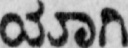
ಯಾಗಿ
